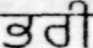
ਭਰੀ
